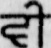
ਵੀ
